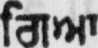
ਗਿਆ
